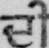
ਦੀ
